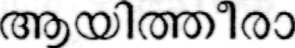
ആയിത്തീരാ
